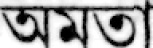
অমতা
